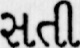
સતી
